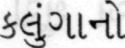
કલુંગાનો
